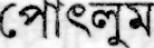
পোৎলুম
